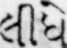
લીધે
